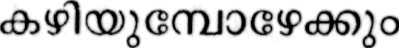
കഴിയുമ്പോഴേക്കും
